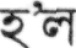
হ'ল
